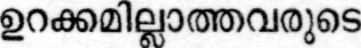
ഉറക്കമില്ലാത്തവരുടെ
